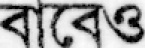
বাবেও
